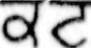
ਕਟ
